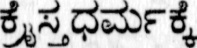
ಕ್ರೈಸ್ತಧರ್ಮಕ್ಕೆ
